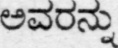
ಅವರನ್ನು
